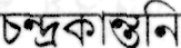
চন্দ্রকান্তনি
